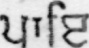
ਪਾਇ
